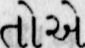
તોએ
